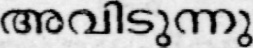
അവിടുന്നു
